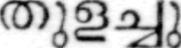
തുളച്ചു
